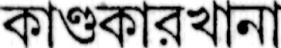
কাণ্ডকারখানা
